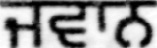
ਜਵਾਨ
